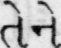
તેને
